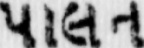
પાલન
